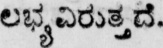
ಲಭ್ಯವಿರುತ್ತದೆ.
